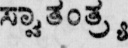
ಸ್ವಾತಂತ್ರ್ಯ
